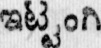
ಇಟ್ಟಂಗಿ
